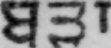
ਬੜਾ
